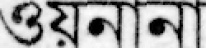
ওয়নানা
